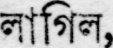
লাগিল,
